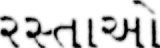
રસ્તાઓ
